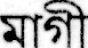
মাগী
